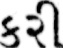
કરી
